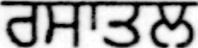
ਰਸਾਤਲ
